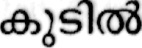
കുടില്‍
